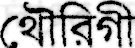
থৌরিগী
